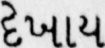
દેખાય
